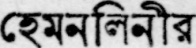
হেমনলিনীর
